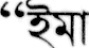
“ইমা
